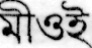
মীওই
